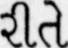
રીતે
